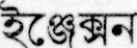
ইঞ্জেক্সন
